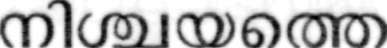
നിശ്ചയത്തെ
